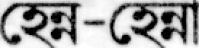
হেন্ন-হেন্না
